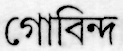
গোবিন্দ
